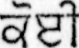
ਕੋਈ
